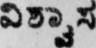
ವಿಶ್ವಾಸ
